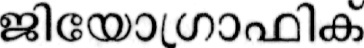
ജിയോഗ്രാഫിക്
